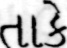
તાકે
